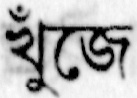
খুঁজে
